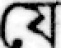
যে
